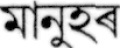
মানুহৰ
